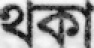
থকা
